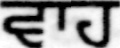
ਵਾਹ
